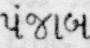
પંજાબ
